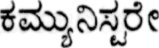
ಕಮ್ಯುನಿಸ್ಟರೇ
